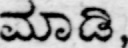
ಮಾಡಿ,
